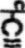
ਨੂੰ
